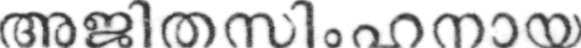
അജിതസിംഹനായ
